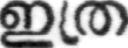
ഇത്ര
